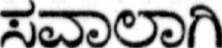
ಸವಾಲಾಗಿ
